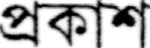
প্রকাশ
